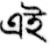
এই
